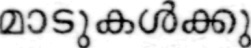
മാടുകള്‍ക്കു
